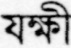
যক্ষী
